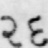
રદ
